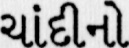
ચાંદીનો
